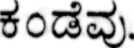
ಕಂಡೆವು.
